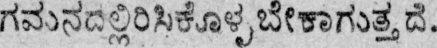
ಗಮನದಲ್ಲಿರಿಸಿಕೊಳ್ಳಬೇಕಾಗುತ್ತದೆ.
